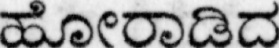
ಹೋರಾಡಿದ
